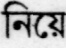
নিয়ে
